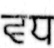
ਵਧ
